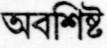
অবশিষ্ট
